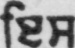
ਇਸ
